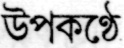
উপকণ্ঠে
